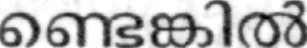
ണ്ടെങ്കില്‍
